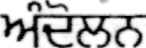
ਅੰਦੋਲਨ
